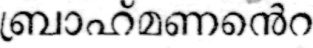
ബ്രാഹ്മണന്റെ
